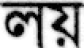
লয়
